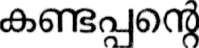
കണ്ടപ്പന്റെ
